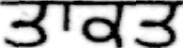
ਤਾਕਤ
